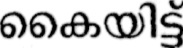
കൈയിട്ട്
